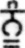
ਨੂੰ
